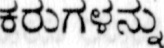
ಕರುಗಳನ್ನು
